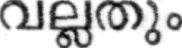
വല്ലതും
